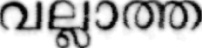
വല്ലാത്ത
